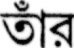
তাঁর
